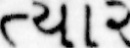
ત્યાર
